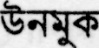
উনমুক
